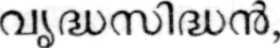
വൃദ്ധസിദ്ധന്‍,
